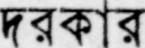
দরকার
